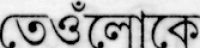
তেওঁলোকে
